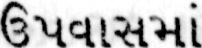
ઉપવાસમાં
